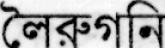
লৈরুগনি
